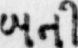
બની
